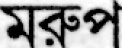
মরুপ
